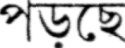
পড়ছে
